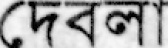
দেবলা
